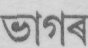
ভাগৰ
